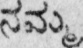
ನಮ್ಮ
